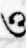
ও
